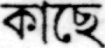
কাছে
